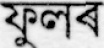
ফুলৰ
